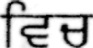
ਵਿਚ
